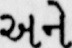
અને
